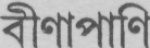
বীণাপাণি
